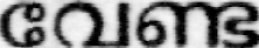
വേണ്ട
